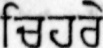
ਚਿਹਰੇ
